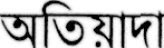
অতিয়াদা
